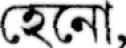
হেনো,
